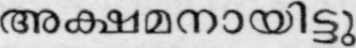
അക്ഷമനായിട്ടു
